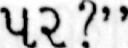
પર?"
